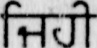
ਜਿਹੀ
